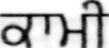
ਕਾਮੀ
